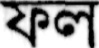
ফল
